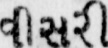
વીસરી
